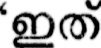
‘ഇത്
